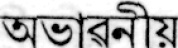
অভাৱনীয়
